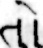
તો
